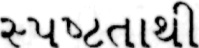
સ્પષ્ટતાથી
